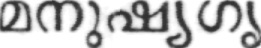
മനുഷ്യഗൃ
